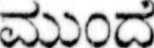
ಮುಂದೆ
